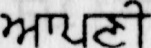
ਆਪਣੀ
